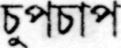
চুপচাপ
